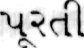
પૂરતી
